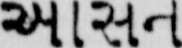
આસન
